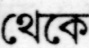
থেকে
